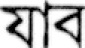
যাব
